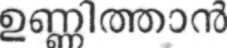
ഉണ്ണിത്താന്‍
